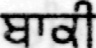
ਬਾਕੀ
